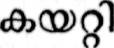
കയറ്റി
